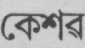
কেশৱ
